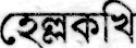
হেল্লকখি
